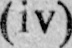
(iv)
